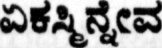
ಏಕಸ್ಮಿನ್ನೇವ
